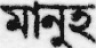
মানুহ
